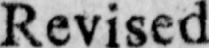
Revised
